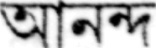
আনন্দ
